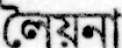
লৈয়না
